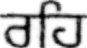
ਰਹਿ
